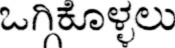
ಒಗ್ಗಿಕೊಳ್ಳಲು
